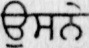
ਉਸਨੇ
